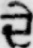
ਦੇ
